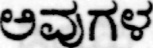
ಅವುಗಳ
